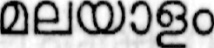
മലയാളം
